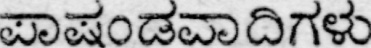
ಪಾಷಂಡವಾದಿಗಳು
